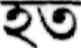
হত
